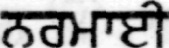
ਨਰਮਾਈ
